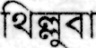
থিল্লুবা
